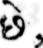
છે,
